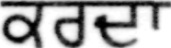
ਕਰਦਾ
